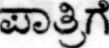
ಪಾತ್ರಿಗೆ
